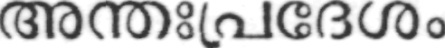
അന്തഃപ്രദേശം
